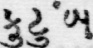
કુટુંબ
